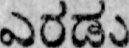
ಎರಡು
